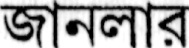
জানলার
